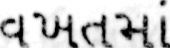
વખતમાં
